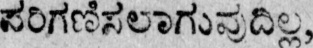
ಪರಿಗಣಿಸಲಾಗುವುದಿಲ್ಲ,
